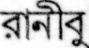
রানীবু
